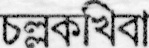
চল্লকখিবা
